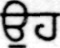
ਉਹ
